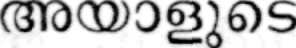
അയാളുടെ
